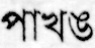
পাখঙ
